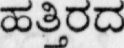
ಹತ್ತಿರದ
